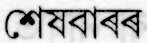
শেষবাৰৰ
